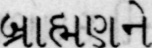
બ્રાહ્મણને
